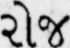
રોજ
